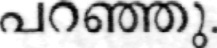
പറഞ്ഞു.
